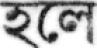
হলে
